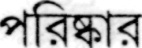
পরিষ্কার
